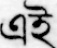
এই
